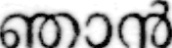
ഞാന്‍
